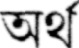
অর্থ
